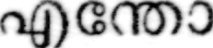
എന്തോ
